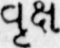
વૃક્ષ
